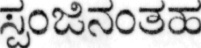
ಸ್ಪಂಜಿನಂತಹ
